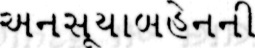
અનસૂયાબહેનની
